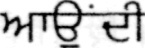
ਆਉਂਦੀ
